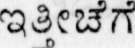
ಇತ್ತೀಚೆಗೆ
